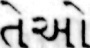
તેઓ
